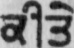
ਕੀਤੇ
